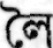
লৈ
